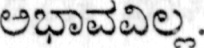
ಅಭಾವವಿಲ್ಲ.
